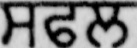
ਸਫਲ
